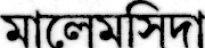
মালেমসিদা
